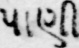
પાણી
